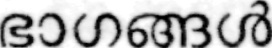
ഭാഗങ്ങള്‍
